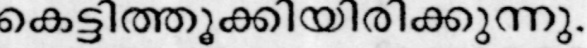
കെട്ടിത്തൂക്കിയിരിക്കുന്നു.
